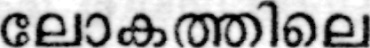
ലോകത്തിലെ
